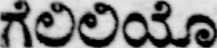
ಗೆಲಿಲಿಯೊ
